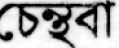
চেন্থবা
